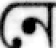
নে
